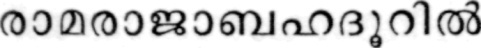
രാമരാജാബഹദൂറില്‍
